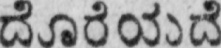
ದೊರೆಯದೆ
